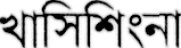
খাসিশিংনা
